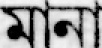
মানা
